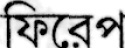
ফিরেপ
